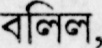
বলিল,
